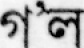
গ'ল
